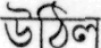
উঠিল
